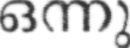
ഒന്നു
